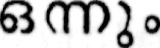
ഒന്നും
